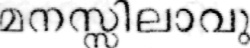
മനസ്സിലാവു
